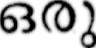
ഒരു
